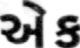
એક
